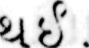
થઈ.
